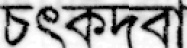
চৎকদবা
